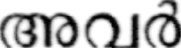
അവര്‍
